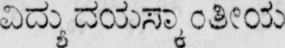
ವಿದ್ಯುದಯಸ್ಕಾಂತೀಯ
